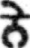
ਨੇ
